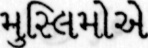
મુસ્લિમોએ
